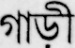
গাড়ী
